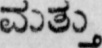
ಮತ್ತು
